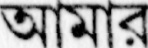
আমার
